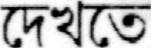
দেখতে
